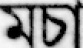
মচা
